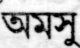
অমসু
